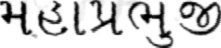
મહાપ્રભુજી
